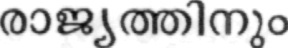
രാജ്യത്തിനും
